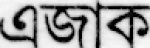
এজাক
